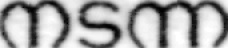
നടന്ന
